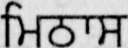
ਮਿਠਾਸ
